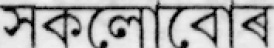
সকলোবোৰ
